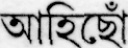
আহিছোঁ
